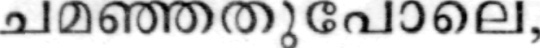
ചമഞ്ഞതുപോലെ,
